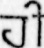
ਹੀ
